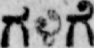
ಗಳಿಗೆ
